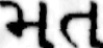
મત
